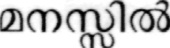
മനസ്സില്‍
